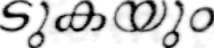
ടുകയും
